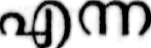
എന്ന
